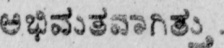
ಅಭಿಮತವಾಗಿತ್ತು.
